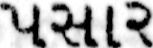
પસાર
